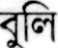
বুলি
